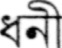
ধনী
